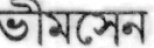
ভীমসেন
